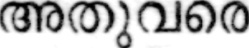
അതുവരെ
